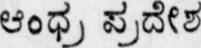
ಆಂಧ್ರಪ್ರದೇಶ
